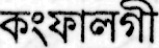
কংফালগী
